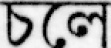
চলে
